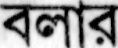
বলার
